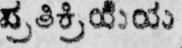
ಪ್ರತಿಕ್ರಿಯೆಯ
